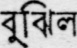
বুঝিল
